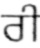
ਰੀ
